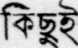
কিছুই
